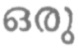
ഒരു
